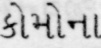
કોમોના
